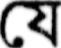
যে
